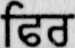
ਫਿਰ
